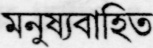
মনুষ্যবাহিত
